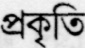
প্রকৃতি
